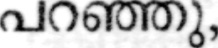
പറഞ്ഞു,
